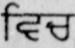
ਵਿਚ
